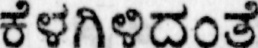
ಕೆಳಗಿಳಿದಂತೆ
